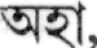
অহা,
